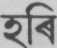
হৰি
